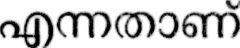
എന്നതാണ്
